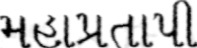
મહાપ્રતાપી
